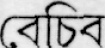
বেচিব
